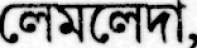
লেমলেদা,
